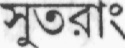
সুতরাং
